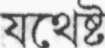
যথেষ্ট
